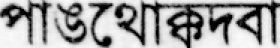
পাঙথোক্কদবা
